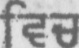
ਵਿਚ
